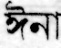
ঈনা
